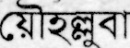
য়ৌহল্লুবা
